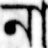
না
